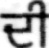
ਦੀ
